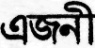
এজনী
